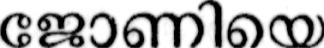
ജോണിയെ
